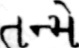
તન્મે
